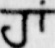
ਹਾਂ
